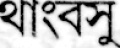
থাংবসু
